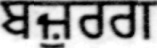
ਬਜ਼ੁਰਗ
